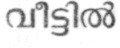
വീട്ടില്‍
